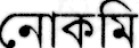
নোকমি
